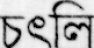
চৎলি
